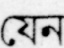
যেন
